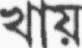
খায়
